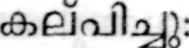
കല്പിച്ചു:
